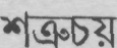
শত্ৰুচয়
